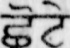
ਛੋਟੇ
